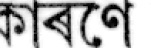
কাৰণে
